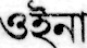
ওইনা
